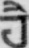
ਹੈ
